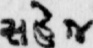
સહેજ
